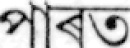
পাৰত
